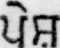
ਪੇਸ਼
